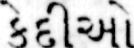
કેદીઓ
